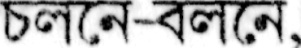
চলনে-বলনে,
